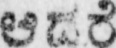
ಆದರೆ
